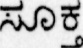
ಸೂಕ್ತ
